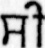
ਸੀ
